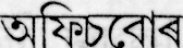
অফিচবোৰ
